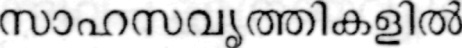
സാഹസവൃത്തികളില്‍
